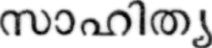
സാഹിത്യ
